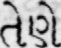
તેણે
